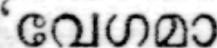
‘വേഗമാ
